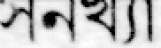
সনখ্যা
